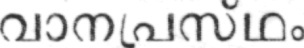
വാനപ്രസ്ഥം
